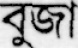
বুজা
